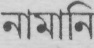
নামানি
